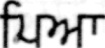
ਪਿਆ
